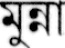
মুন্না
